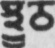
ਝੂਠ
